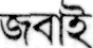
জবাই
